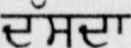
ਦੱਸਦਾ
